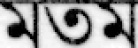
মতম
